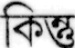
কিন্তু
